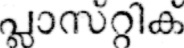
പ്ലാസ്റ്റിക്
